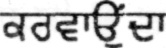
ਕਰਵਾਉਂਦਾ
